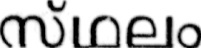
സ്ഥലം
